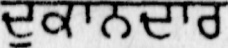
ਦੁਕਾਨਦਾਰ
